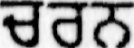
ਚਰਨ
